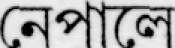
নেপালে
